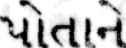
પોતાને
